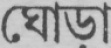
ঘোড়া
